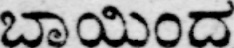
ಬಾಯಿಂದ
